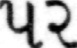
પર
